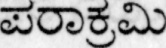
ಪರಾಕ್ರಮಿ
